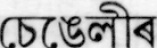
চেঙেলীৰ
